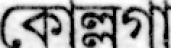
কোল্লগা
